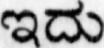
ಇದು
